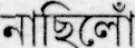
নাছিলোঁ
